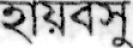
হায়বসু
